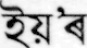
ইয়'ৰ
